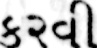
કરવી
